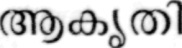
ആകൃതി
